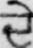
ਦੇ
